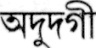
অদুদগী
